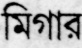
মিগার
